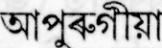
আপুৰুগীয়া
